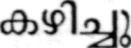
കഴിച്ചു
